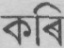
কৰি
